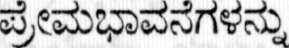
ಪ್ರೇಮಭಾವನೆಗಳನ್ನು
